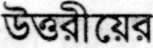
উত্তরীয়ের
